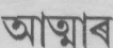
আত্মাৰ
